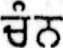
ਚੰਨ
